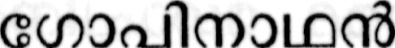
ഗോപിനാഥന്‍
